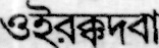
ওইরক্কদবা
